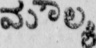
ಮೌಲ್ಯ
